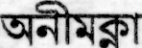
অনীমক্না
